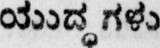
ಯುದ್ಧಗಳು
